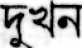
দুখন
